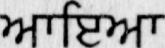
ਆਇਆ
